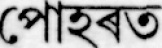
পোহৰত
